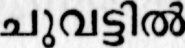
ചുവട്ടില്‍
